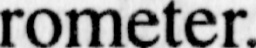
rometer.
